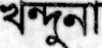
খন্দুনা
